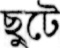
ছুটে
